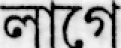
লাগে
